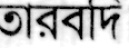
তারবদি
